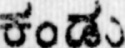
ಕಂಡು
